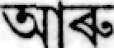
আৰু
